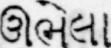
ઊભેલા
